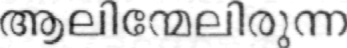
ആലിന്മേലിരുന്ന
